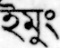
ইমুং
